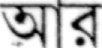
আর
